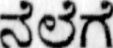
ನೆಲೆಗೆ
